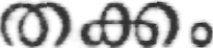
തക്കം
